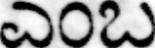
ಎಂಬ
